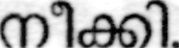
നീക്കി.
